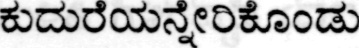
ಕುದುರೆಯನ್ನೇರಿಕೊಂಡು
